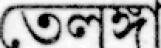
তেলঙ্গা
